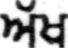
ਅੱਖ
